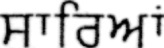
ਸਾਰਿਆਂ
